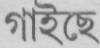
গাইছে
